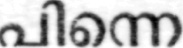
പിന്നെ
